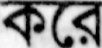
করে
